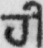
ਹੀ
